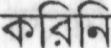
করিনি
